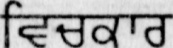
ਵਿਚਕਾਰ
